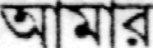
আমার
